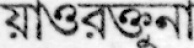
য়াওরক্তুনা
